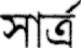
সার্ত্র
